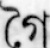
গৈ
